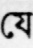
যে
